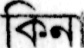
কিনা
